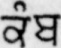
ਕੰਬ
